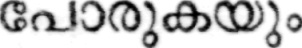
പോരുകയും
